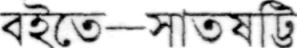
বইতে–সাতষট্টি
